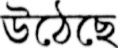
উঠেছে
